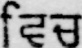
ਵਿਚ
